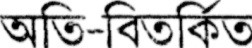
অতি-বিতর্কিত
